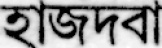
হাজদবা
